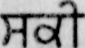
ਸਕੀ
